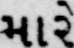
મારે
